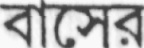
বাসের
